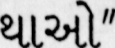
થાઓ"
